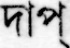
দাপ্
